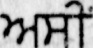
ਅਸੀਂ
